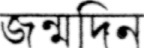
জন্মদিন
